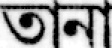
তানা
